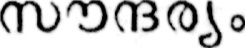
സൌന്ദര്യം
